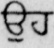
ਉਹ
